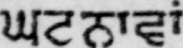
ਘਟਨਾਵਾਂ
